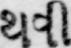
થવી
